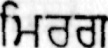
ਮਿਰਗ
